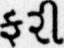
ફરી
